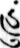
હું
